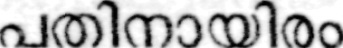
പതിനായിരം
